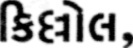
કિલ્લોલ,
